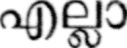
എല്ലാ
